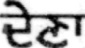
ਦੇਣਾ
